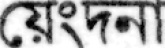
য়েংদনা
